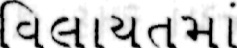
વિલાયતમાં
